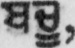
ਬਚੂ,
